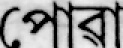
পোৱা
